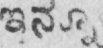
ಇನ್ನೂ
